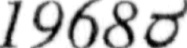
1968ರ
